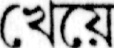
খেয়ে
